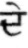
ਦੇ
